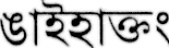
ঙাইহাক্তং
